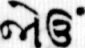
જોઉં
